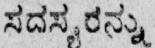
ಸದಸ್ಯರನ್ನು
